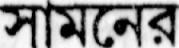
সামনের
